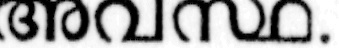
അവസ്ഥ.
